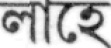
লাহে
